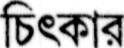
চিৎকার
